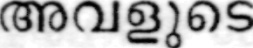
അവളുടെ
